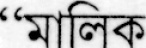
"মালিক
